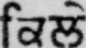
ਕਿਲੇ
